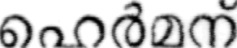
ഹെര്‍മന്
